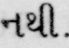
નથી.
